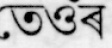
তেওঁৰ
